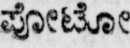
ಫೋಟೋ
